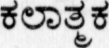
ಕಲಾತ್ಮಕ
